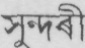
সুন্দৰী
